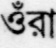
ওঁরা
